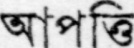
আপত্তি
